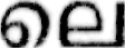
ലെ
